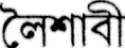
লৈশাবী
